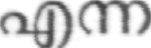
എന്ന
